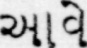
આવે
